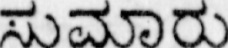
ಸುಮಾರು
